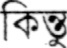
কিন্তু
